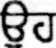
ਉਹ
